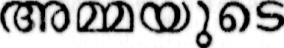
അമ്മയുടെ
